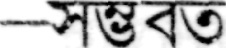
-সম্ভবত
